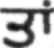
ਤਾਂ
